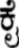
ಕೈ
